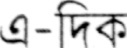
এ-দিক
